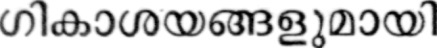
ഗികാശയങ്ങളുമായി
